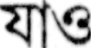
যাও
